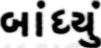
બાંધ્યું
